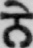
ਨੇ
